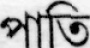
পাতি
